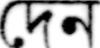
দেন
